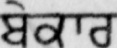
ਬੇਕਾਰ
